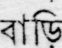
বাড়ি
